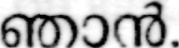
ഞാന്‍.
